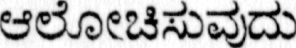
ಆಲೋಚಿಸುವುದು
